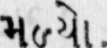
મળ્યો.
